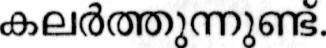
കലര്‍ത്തുന്നുണ്ട്.
